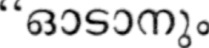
"ഓടാനും
